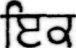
ਇਕ
